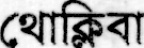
থোক্লিবা
